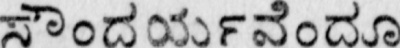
ಸೌಂದರ್ಯವೆಂದೂ
